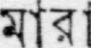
মারা
